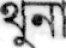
থুনা
